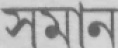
সমান
